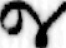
જ
